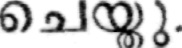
ചെയ്തു.
